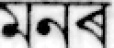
মনৰ
